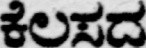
ಕೆಲಸದ
